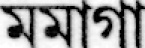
মমাগা
